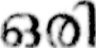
ഒരി
